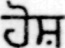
ਹੋਸ਼
